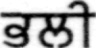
ਭਲੀ
